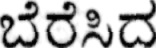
ಬೆರೆಸಿದ
